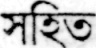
সহিত
